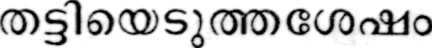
തട്ടിയെടുത്തശേഷം
